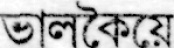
ভালকৈয়ে
